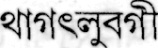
থাগৎলুবগী
